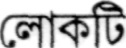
লোকটি
